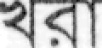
খরা
